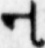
ન
